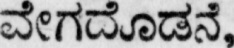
ವೇಗದೊಡನೆ,
